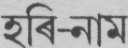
হৰি-নাম
